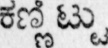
ಕಣ್ಣಿಟ್ಟು
